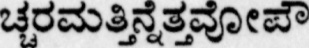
ಚ್ಚರಮತ್ತಿನ್ನೆತ್ತವೋಪೌ
